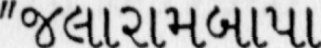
"જલારામબાપા
